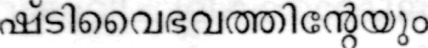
ഷ്ടിവൈഭവത്തിന്റേയും
